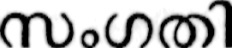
സംഗതി
